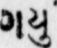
ગયું
